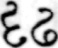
દૃઢ
